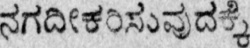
ನಗದೀಕರಿಸುವುದಕ್ಕೆ
